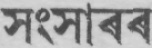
সংসাৰৰ
